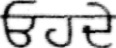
ਓਹਦੇ
